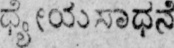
ಧ್ಯೇಯಸಾಧನೆ
